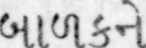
બાળકને
